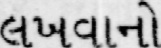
લખવાનો
